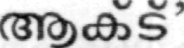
ആക്ട'
